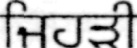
ਜਿਹੜੀ
